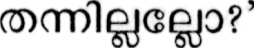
തന്നില്ലല്ലോ?'
